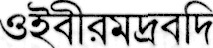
ওইবীরমদ্রবদি
